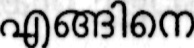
എങ്ങിനെ
